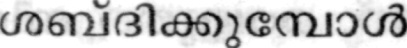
ശബ്ദിക്കുമ്പോള്‍
